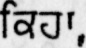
ਕਿਹਾ,
